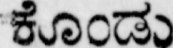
ಕೊಂಡು
